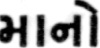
માનો
